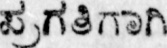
ಪ್ರಗತಿಗಾಗಿ
